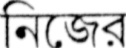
নিজের
